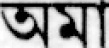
অমা
